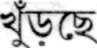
খুঁড়ছে
